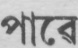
পাৱে
